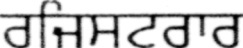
ਰਜਿਸਟਰਾਰ
